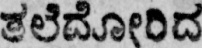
ತಲೆದೋರಿದ
